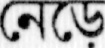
নেড়ে
